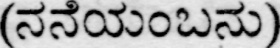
(ನನೆಯಂಬನು)
